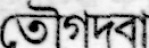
তৌগদবা
